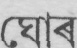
ঘোৰ
